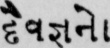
દૈવજ્ઞનો
